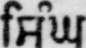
ਸਿੰਘ
